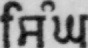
ਸਿੰਘ
